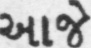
આજે
